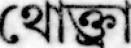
থোক্ত্রা
